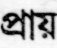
প্রায়
